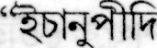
“ইচানুপীদি
